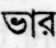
ভার
